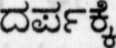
ದರ್ಪಕ್ಕೆ
